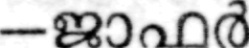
-ജാഫര്‍
